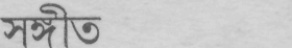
সঙ্গীত
